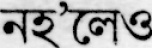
নহ'লেও
